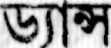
ড্যান্স
